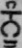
ਨੂੰ
